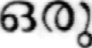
ഒരു
